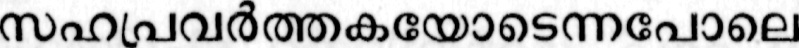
സഹപ്രവര്‍ത്തകയോടെന്നപോലെ
